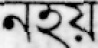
নহয়
